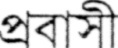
প্রবাসী
